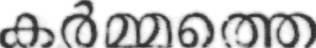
കര്‍മ്മത്തെ
